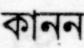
কানন
